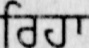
ਰਿਹਾ
